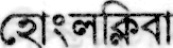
হোংলক্লিবা
